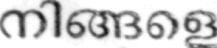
നിങ്ങളെ
